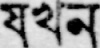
যখন
